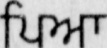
ਪਿਆ
